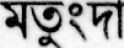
মতুংদা
